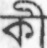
কী
